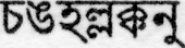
চঙহল্লক্কনু
